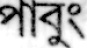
পাবুং
